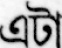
এটা
